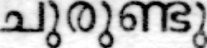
ചുരുണ്ടു
